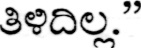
ತಿಳಿದಿಲ್ಲ."
